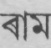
ৰাম
